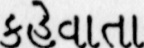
કહેવાતા
